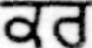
ਕਰ
